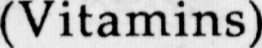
(Vitamins)
